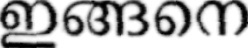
ഇങ്ങനെ
